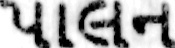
પાલન
